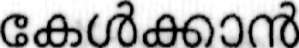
കേള്‍ക്കാന്‍
